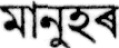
মানুহৰ
